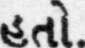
હતો.
